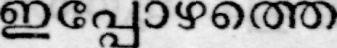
ഇപ്പോഴത്തെ
